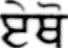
ਏਥੋ
